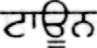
ਟਾਊਨ
